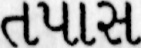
તપાસ
